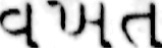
વખત
